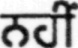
ਨਹੀਂ
